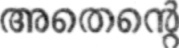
അതെന്റെ
